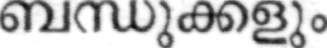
ബന്ധുക്കളും
